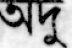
অদু
